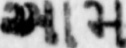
આમ
